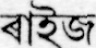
ৰাইজ
